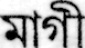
মাগী
